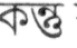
কিন্তু
